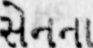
સેનના
